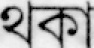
থকা
